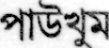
পাখুম
